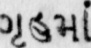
ગૃહમાં
